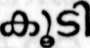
കൂടി
